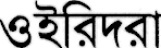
ওইরিদরা
